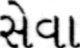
સેવા
